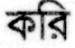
করি
